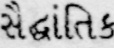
સૈદ્ધાંતિક
